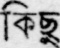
কিছু
